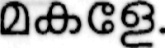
മകളേ.
